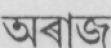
অৰাজ
